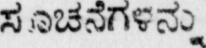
ಸೂಚನೆಗಳನ್ನು
